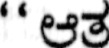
"ಆತ
